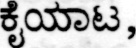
ಕೈಯಾಟ,
